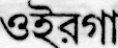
ওইরগা
